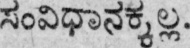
ಸಂವಿಧಾನಕ್ಕಲ್ಲ.
